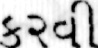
કરવી
